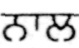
ਨਾਲ
